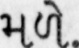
મળે.
